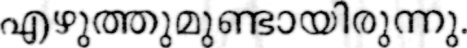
എഴുത്തുമുണ്ടായിരുന്നു.
